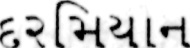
દરમિયાન
